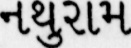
નથુરામ
